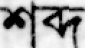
শব্দ
